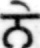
ਨੇ
